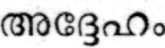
അദ്ദേഹം
